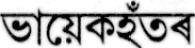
ভায়েকহঁতৰ
